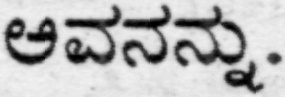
ಅವನನ್ನು
